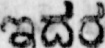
ಇದರ
